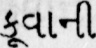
કૂવાની
